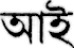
আই
